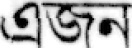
এজন
